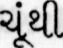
ચૂંથી
